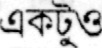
একটুও
